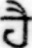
ਹੈ
